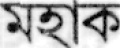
মহাক
